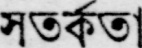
সতর্কতা
